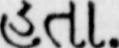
હતા.
